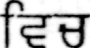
ਵਿਚ
